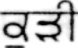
ਕੁੜੀ
